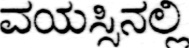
ವಯಸ್ಸಿನಲ್ಲಿ
